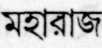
মহারাজ
